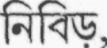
নিবিড়,
